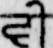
ਵੀ
